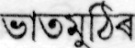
ভাতমুঠিৰ
